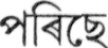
পৰিছে
